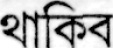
থাকিব
